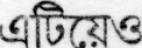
এটিয়েও
